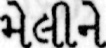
મેલીને
